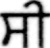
ਸੀ
